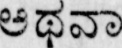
ಅಥವಾ
